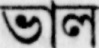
ভাল
